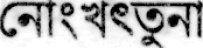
নোংখৎতুনা
